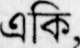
একি,
